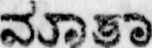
ಮಾತಾ
